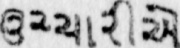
ઉચ્ચારીએ
